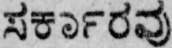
ಸರ್ಕಾರವು
